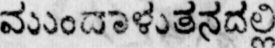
ಮುಂದಾಳುತನದಲ್ಲಿ
